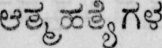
ಆತ್ಮಹತ್ಯೆಗಳ
